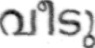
വീടു
